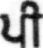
ਪੀ
